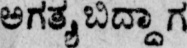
ಅಗತ್ಯಬಿದ್ದಾಗ
